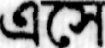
এসে
